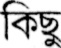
কিছু
